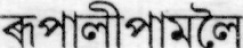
ৰূপালীপামলৈ
